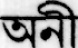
অনী
